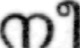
നീ
